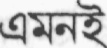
এমনই
